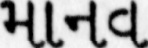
માનવ
